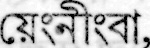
য়েংনীংবা,
